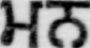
ਮਨ
